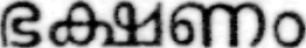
ഭക്ഷണം
